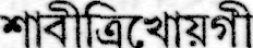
শাবীত্রিখোয়গী
